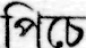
পিচে
